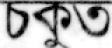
চকুত
